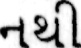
નથી
